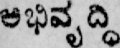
ಅಭಿವೃದ್ಧಿ
